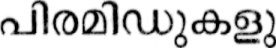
പിരമിഡുകളു
